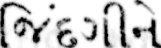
જિંદગીને
